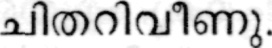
ചിതറിവീണു.
